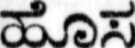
ಹೊಸ
